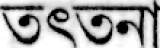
তৎতনা
